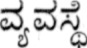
ವ್ಯವಸ್ಥೆ
